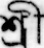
শ্রী
